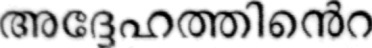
അദ്ദേഹത്തിന്റെ
